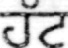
ਹੱਟ
